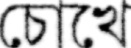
চোখে
